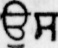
ਉਸ
